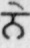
ਨੇ
